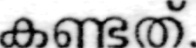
കണ്ടത്.
